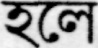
হলে
